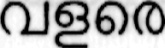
വളരെ
